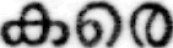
കരെ
